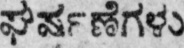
ಘರ್ಷಣೆಗಳು
